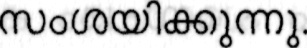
സംശയിക്കുന്നു.
